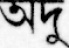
অদু
